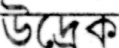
উদ্রেক
